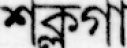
শক্লগা
